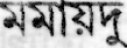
মমায়দু
